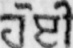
ਹੋਈ
